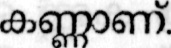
കണ്ണാണ്.
